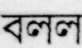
বলল
